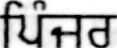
ਪਿੰਜਰ
